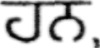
ਹਨ,
